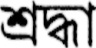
শ্রদ্ধা
